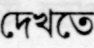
দেখতে
